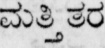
ಮತ್ತಿತರ
